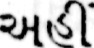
અહીં
